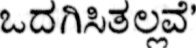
ಒದಗಿಸಿತಲ್ಲವೆ'
